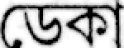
ডেকা
